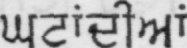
ਘਟਾਂਦੀਆਂ
